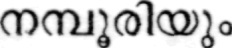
നമ്പൂരിയും
